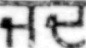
ਜਦ
